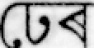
ঢেৰ
